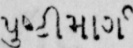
પુષ્ટીમાર્ગ
